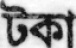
টকা
